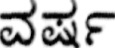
ವರ್ಷ
